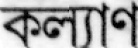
কল্যাণ
